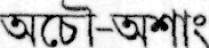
অচৌ-অশাং
